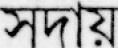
সদায়
